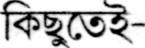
কিছুতেই-
